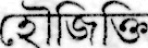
হৌজিক্তি
